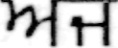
ਅਜ
